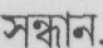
সন্ধান,
